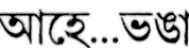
আহে...ভঙা
